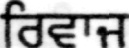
ਰਿਵਾਜ
